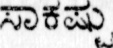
ಸಾಕಷ್ಟು
